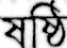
ষষ্ঠি
